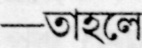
–তাহলে
